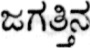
ಜಗತ್ತಿನ
